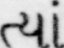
ત્યાં
